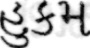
હુકમ
